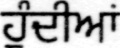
ਹੁੰਦੀਆਂ
